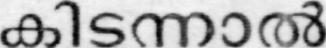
കിടന്നാല്‍
